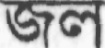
জল
